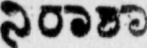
ನಿರಾಶಾ
